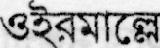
ওইরমাল্লে
